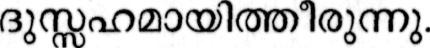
ദുസ്സഹമായിത്തീരുന്നു.
